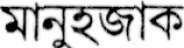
মানুহজাক
